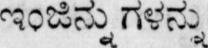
ಇಂಜಿನ್ನುಗಳನ್ನು
